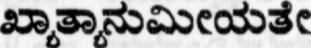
ಖ್ಯಾತ್ಯಾನುಮೀಯತೇ
